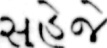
સહેજે
